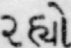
રહ્યો
